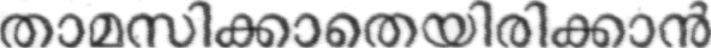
താമസിക്കാതെയിരിക്കാന്‍
